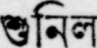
শুনিল
